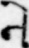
ને
